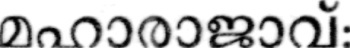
മഹാരാജാവ്:
